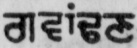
ਗਵਾਂਢਣ
